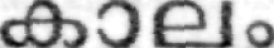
കാലം
